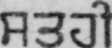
ਸਤਹੀ
